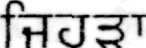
ਜਿਹੜਾ
